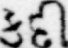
કદી
